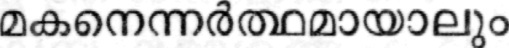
മകനെന്നര്‍ത്ഥമായാലും
